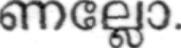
ണല്ലോ.
